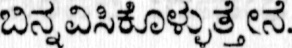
ಬಿನ್ನವಿಸಿಕೊಳ್ಳುತ್ತೇನೆ.
